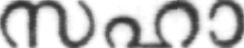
സഹാ
